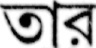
তার
